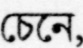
চেনে,
